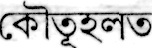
কৌতূহলত
